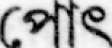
পোৎ
